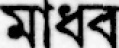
মাধব
